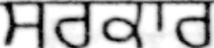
ਸਰਕਾਰ
